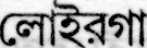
লোইরগা
